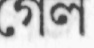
গেল
